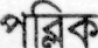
পব্লিক
